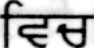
ਵਿਚ
